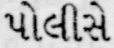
પોલીસે
